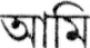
আমি
